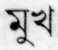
মুখ
